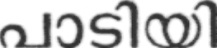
പാടിയി
